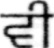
ਵੀ
